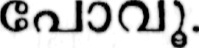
പോവൂ.
